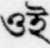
ওই
